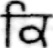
ਕਿ
